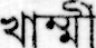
খাম্মী
